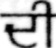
ਦੀ
